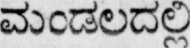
ಮಂಡಲದಲ್ಲಿ
